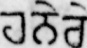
ਹਨੇਰੇ
